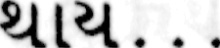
થાય...
